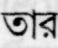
তার
